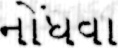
નોંધવા
